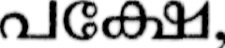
പക്ഷേ,
